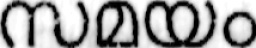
സമയം
